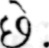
છે.
